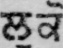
ਲੁਕੋ
